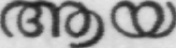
ആയ
